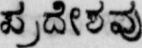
ಪ್ರದೇಶವು
